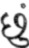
છું
